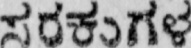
ಸರಕುಗಳ
